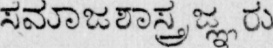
ಸಮಾಜಶಾಸ್ತ್ರಜ್ಞರು
